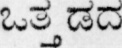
ಒತ್ತಡದ
